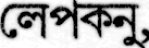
লেপকনু,
